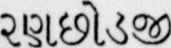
રણછોડજી
